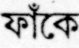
ফাঁকে
